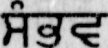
ਸੰਭਵ
